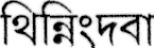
থিন্নিংদবা
